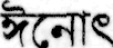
ঈনোৎ
